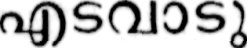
എടവാടു
